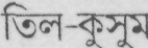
তিল-কুসুম
